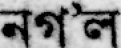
নগ'ল
